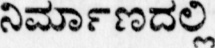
ನಿರ್ಮಾಣದಲ್ಲಿ
